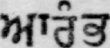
ਆਰੰਭ
